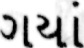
ગયાં
